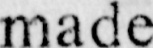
made
